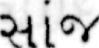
સાંજ
